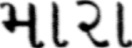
મારા
